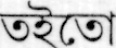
তইতো
